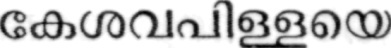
കേശവപിള്ളയെ
